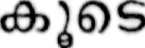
കൂടെ
